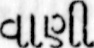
વાણી
